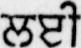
ਲਈ
